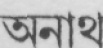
অনাথ
